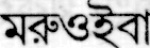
মরুওইবা
